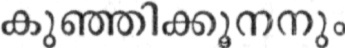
കുഞ്ഞിക്കൂനനും
